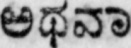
ಅಥವಾ
